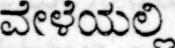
ವೇಳೆಯಲ್ಲಿ
